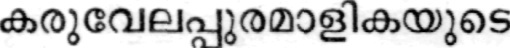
കരുവേലപ്പുരമാളികയുടെ
